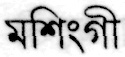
মশিংগী
